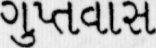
ગુપ્તવાસ
